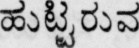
ಹುಟ್ಟಿರುವ
